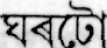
ঘৰটো
